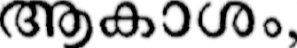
ആകാശം,
